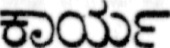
ಕಾರ್ಯ
